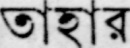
তাহার
